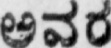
ಅವರ
